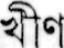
খীণ
